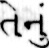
તેનું
